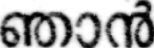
ഞാന്‍
